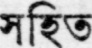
সহিত
